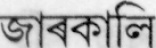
জাৰকালি
